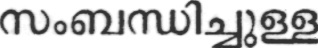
സംബന്ധിച്ചുള്ള
